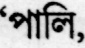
‘পালি,
